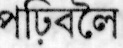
পঢ়িবলৈ
